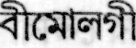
বীমোলগী
